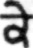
ਕੇ
